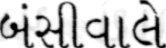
બંસીવાલે
